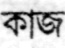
কাজ
